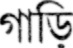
গাড়ি
